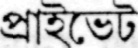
প্রাইভেট
